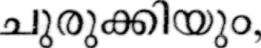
ചുരുക്കിയും,
